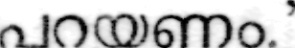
പറയണം.’
